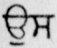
ਉਸ
